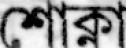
শোক্না
